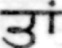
ਤਾਂ
